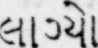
લાગ્યો
